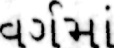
વર્ગમાં
